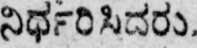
ನಿರ್ಧರಿಸಿದರು.
